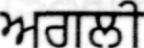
ਅਗਲੀ
